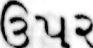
ઉપર
